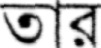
তার
